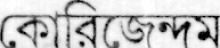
কোরিজেন্দম
